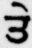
ਤੇ
